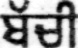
ਬੱਚੀ
